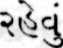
રહેવું
